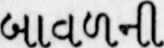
બાવળની
